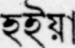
হইয়া
